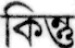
কিন্তু
